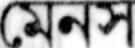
মেনস
